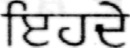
ਇਹਦੇ
